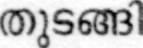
തുടങ്ങി
